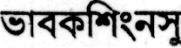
ভাবকশিংনসু
